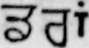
ਡਰਾਂ
